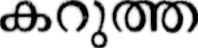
കറുത്ത
